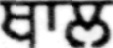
ਥਾਲ
